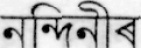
নন্দিনীৰ
